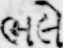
ભલે
